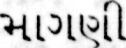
માગણી
